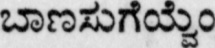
ಬಾಣಸುಗೆಯ್ವೆಂ
